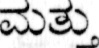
ಮತ್ತು
